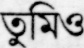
তুমিও
